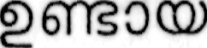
ഉണ്ടായ
